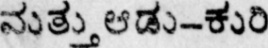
ಮತ್ತುಆಡು-ಕುರಿ
